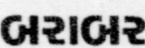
બરાબર
